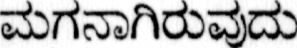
ಮಗನಾಗಿರುವುದು
